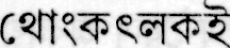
থোংকৎলকই
